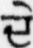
ਦੇ
